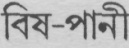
বিষ-পানী
